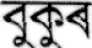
বুকুৰ
